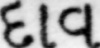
દાવ
